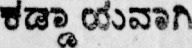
ಕಡ್ಡಾಯವಾಗಿ
